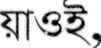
য়াওই,
